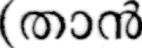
(താന്‍
